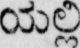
ಯಲ್ಲಿ
